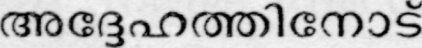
അദ്ദേഹത്തിനോട്
